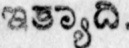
ಇತ್ಯಾದಿ.
